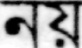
নয়
